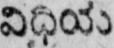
ವಿಧಿಯ
